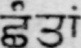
ਛੰਤਾਂ
